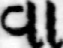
વા
